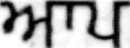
ਆਪ
